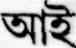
আই
